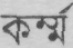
কৰ্ম্ম
